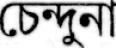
চেন্দুনা
